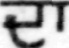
ਦਾ
